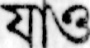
যাও
